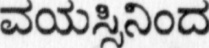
ವಯಸ್ಸಿನಿಂದ
